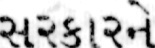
સરકારને
